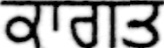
ਕਾਗਤ
